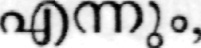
എന്നും,
